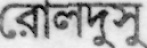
রোলদুসু
